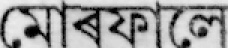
মোৰফালে
